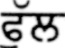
ਫੁੱਲ
